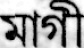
মাগী
